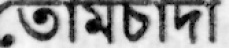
তোমচাদা
